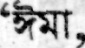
‘ঈমা,
